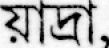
য়াদ্রা,
